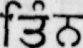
ਤਿੰਨ
